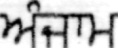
ਅੰਜਾਮ
